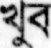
খুব
